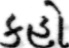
કહો
